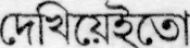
দেখিয়েইতো
